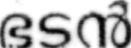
ഭടന്‍
